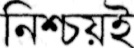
নিশ্চয়ই
